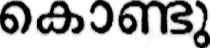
കൊണ്ടു
